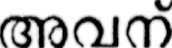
അവന്
